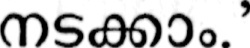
നടക്കാം.’
